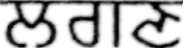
ਲਗਣ
